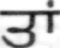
ਤਾਂ
